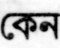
কেন
